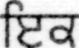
ਇਕ
